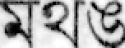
মথঙ
